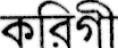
করিগী
